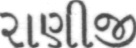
રાણીજી
